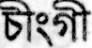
চীংগী
